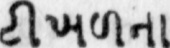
ટીખળના
